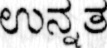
ಉನ್ನತ
